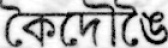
কৈদৌঙৈ
